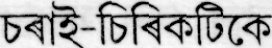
চৰাই-চিৰিকটিকে
